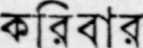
করিবার
